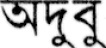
অদুবু
